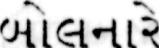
બોલનારે
